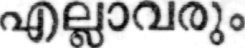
എല്ലാവരും
